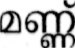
മണ്ണ്
